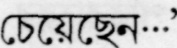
চেয়েছেন...’
